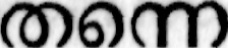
തന്നെ
